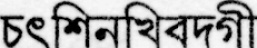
চৎশিনখিবদগী
